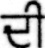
ਦੀ
